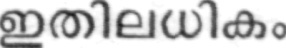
ഇതിലധികം
